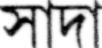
সাদা
